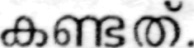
കണ്ടത്.
